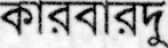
কারবারদু
